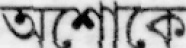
অশোকে
